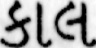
કાલ
